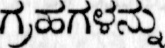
ಗ್ರಹಗಳನ್ನು
